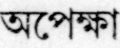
অপেক্ষা
